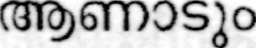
ആണാടും
